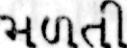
મળતી
